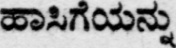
ಹಾಸಿಗೆಯನ್ನು
